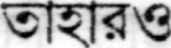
তাহারও
